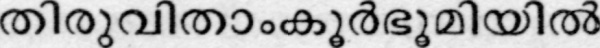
തിരുവിതാംകൂര്‍ഭൂമിയില്‍
